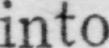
into
